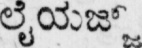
ಲೈಯಜ್ಜ್
